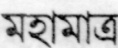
মহামাত্র
